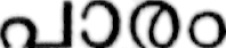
പാരം
